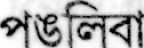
পঙলিবা
